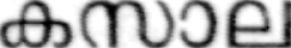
കസാല
